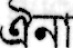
ঐনা
